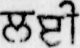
ਲਈ
